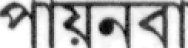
পায়নবা
